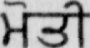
ਮੋਤੀ
